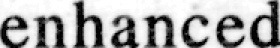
enhanced
